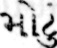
મોટું
